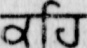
ਕਹਿ
